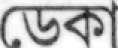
ডেকা
